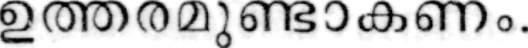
ഉത്തരമുണ്ടാകണം.
